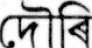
দৌৰি
